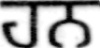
ਹਨ
